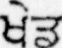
ਖੇਡ
